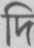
দি
